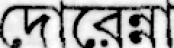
দোরেন্না
